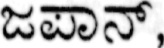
ಜಪಾನ್,
